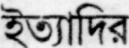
ইত্যাদির
